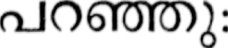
പറഞ്ഞു:
